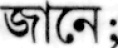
জানে;
